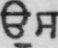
ਉਸ
